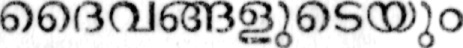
ദൈവങ്ങളുടെയും
